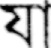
যা
